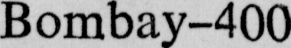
Bombay-400
